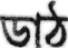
ডাঠ
